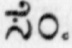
ಸೆಂ.
